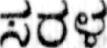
ಸರಳ
